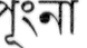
পূংনা
